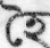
হৈ
